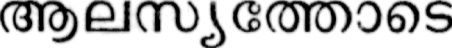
ആലസ്യത്തോടെ
